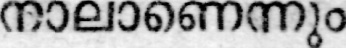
നാലാണെന്നും
